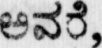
ಅವರೆ,
